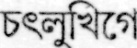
চৎলুখিগে
